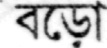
বড়ো
